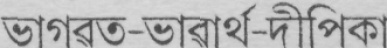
ভাগৱত-ভাৱাৰ্থ-দীপিকা
